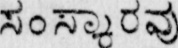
ಸಂಸ್ಕಾರವು
